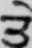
ਤੇ
